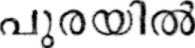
പുരയില്‍
